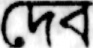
দেব
